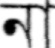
না
